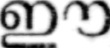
ഈ
